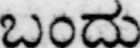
ಬಂದು
